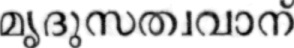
മൃദുസത്വവാന്
